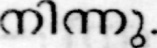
നിന്നു.
